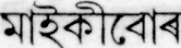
মাইকীবোৰ
